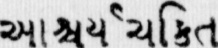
આશ્ચર્યચકિત
